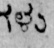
ಗಳು
